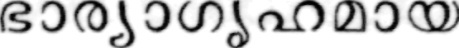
ഭാര്യാഗൃഹമായ
